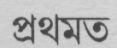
প্ৰথমত
